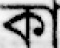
কা
